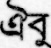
ঐবু
